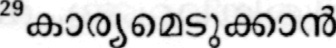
29കാര്യമെടുക്കാന്‍
